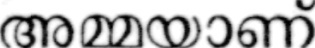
അമ്മയാണ്
